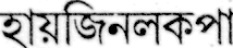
হায়জিনলকপা
